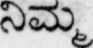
ನಿಮ್ಮ
